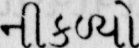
નીકળ્યો
